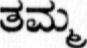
ತಮ್ಮ
